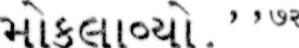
મોકલાવ્યો."૭૨
